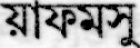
য়াফমসু
